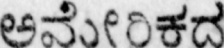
ಅಮೇರಿಕದ
